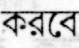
করবে
